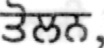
ਤੋਲਨ,
